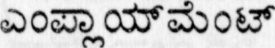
ಎಂಪ್ಲಾಯ್‌ಮೆಂಟ್
